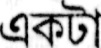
একটা
